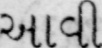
આવી
